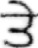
ਤੇ
